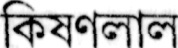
কিষণলাল
